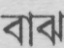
বাঝ
